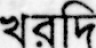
খরদি
